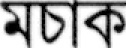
মচাক
